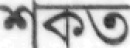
শকত
